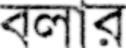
বলার
